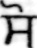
ਸੋ
